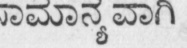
ಸಾಮಾನ್ಯವಾಗಿ
